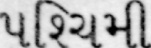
પશ્ચિમી
